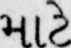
માટે
